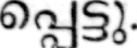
പ്പെട്ടു.
